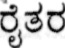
ರೈತರ
